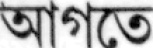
আগতে
